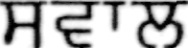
ਸਵਾਲ
